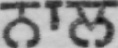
ਨਾਲ
